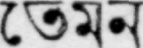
তেমন
